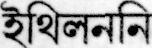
ইথিলননি
